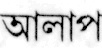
আলাপ
